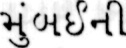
મુંબઈની
